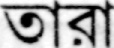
তারা
